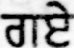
ਗਏ
